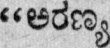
“ಅರಣ್ಯ
